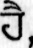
ਹੈ,
